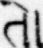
તો
